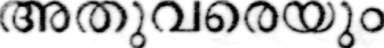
അതുവരെയും
